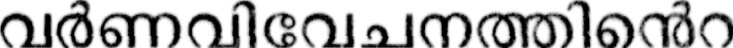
വര്‍ണവിവേചനത്തിന്റെ
